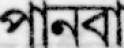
পানবা
